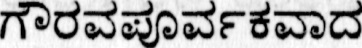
ಗೌರವಪೂರ್ವಕವಾದ
